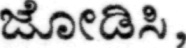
ಜೋಡಿಸಿ,
